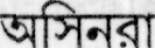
অসিনরা
